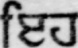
ਇਹ
